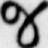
જ
